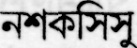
নশকসিসু
